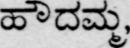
ಹೌದಮ್ಮ,
